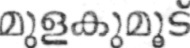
മുളകുമൂട്
